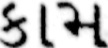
કામ
